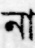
না
